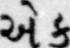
એક
